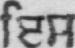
ਇਸ
